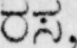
ರಸ,
